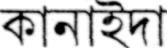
কানাইদা
